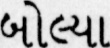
બોલ્યા
